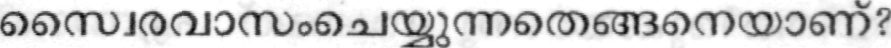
സ്വൈരവാസംചെയ്യുന്നതെങ്ങനെയാണ്?
